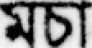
মচা
